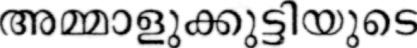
അമ്മാളുക്കുട്ടിയുടെ
